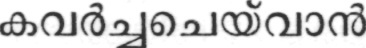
കവര്‍ച്ചചെയ്വാന്‍
